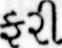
ફરી
